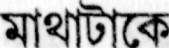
মাথাটাকে
